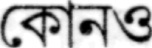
কোনও
